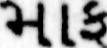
માફ
